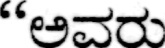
"ಅವರು
